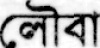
লৌবা
